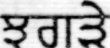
ਝਗੜੇ
